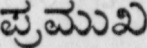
ಪ್ರಮುಖ
